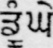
ਡੂੰਘੇ
